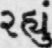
રહ્યું
